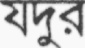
যদুর
